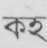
কহ
